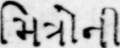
મિત્રોની
